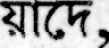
য়াদে,
